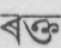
ৰক্ত
